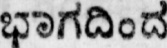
ಭಾಗದಿಂದ
